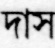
দাস
